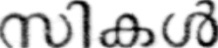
സികള്‍
